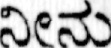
ನೀನು
